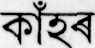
কাঁহৰ
